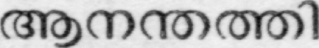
ആനന്തത്തി
